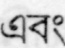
এবং
